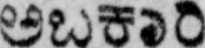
ಅಬಕಾರಿ
